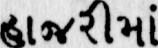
હાજરીમાં
